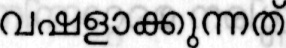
വഷളാക്കുന്നത്
